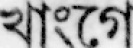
খাংগে
